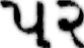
પર
